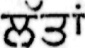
ਲੱਤਾਂ
